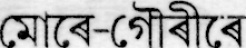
মোৰে-গৌৰীৰে
